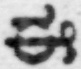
ಈ
